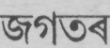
জগতৰ
